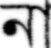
না
